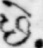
છે.
